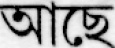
আছে
